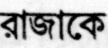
রাজাকে
